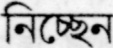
নিচ্ছেন
